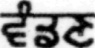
ਵੰਡਣ
